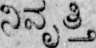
ನಿವೃತ್ತಿ
